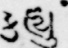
કહ્યું
